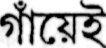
গাঁয়েই
